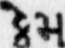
કેમ
